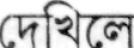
দেখিলে
